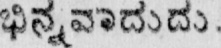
ಭಿನ್ನವಾದುದು.
